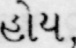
હોય,
